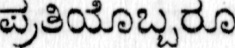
ಪ್ರತಿಯೊಬ್ಬರೂ
